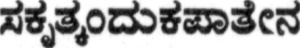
ಸಕೃತ್ಕಂದುಕಪಾತೇನ
